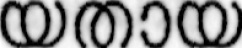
യതായ
